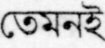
তেমনই
